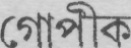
গোপীক
